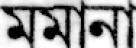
মমানা
